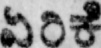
ಏರಿಕೆ
